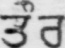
ਤੌਰ
